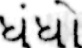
ધંધો
